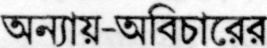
অন্যায়-অবিচারের
